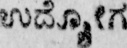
ಉದ್ಯೋಗ
